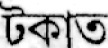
টকাত
